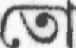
তো
